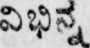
ವಿಭಿನ್ನ
